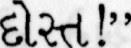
દોસ્ત!"
